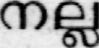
നല്ല
